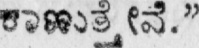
ಕಾಣುತ್ತೇವೆ.”
